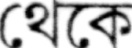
থেকে
